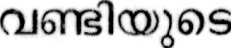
വണ്ടിയുടെ
